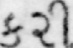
કરી
